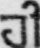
ਹੀ
